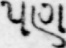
પણ
